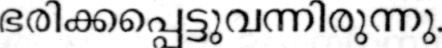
ഭരിക്കപ്പെട്ടുവന്നിരുന്നു.
